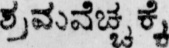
ಶ್ರಮವೆಚ್ಚಕ್ಕೆ
